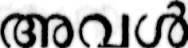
അവള്‍
